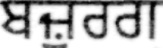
ਬਜ਼ੁਰਗ
